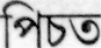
পিচত
